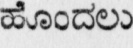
ಹೊಂದಲು
